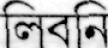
লিবনি
